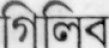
গিলিব
